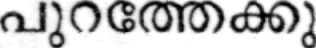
പുറത്തേക്കു
